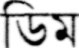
ডিম
